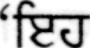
'ਇਹ
